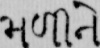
મળીને
